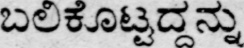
ಬಲಿಕೊಟ್ಟದ್ದನ್ನು
